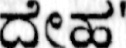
ದೇಹ’
